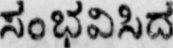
ಸಂಭವಿಸಿದ
